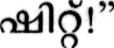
ഷിറ്റ്!”
